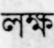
লক্ষ
